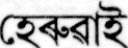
হেৰুৱাই
